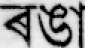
ৰঙা
